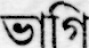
ভাগি
